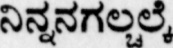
ನಿನ್ನನಗಲ್ಚೆಲ್ಕೆ
